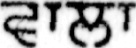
ਵਾਲਾ
